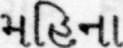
મહિના
